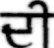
ਦੀ
